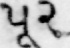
પૂર
